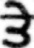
ਤੇ
